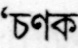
‘চণক
